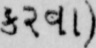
કરવા)
